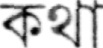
কথা
